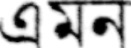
এমন
